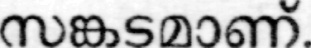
സങ്കടമാണ്.
